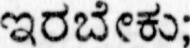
ಇರಬೇಕು;
